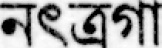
নৎত্রগা
